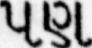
પણ
